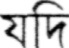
যদি
